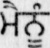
ਮੈਨੂੰ
